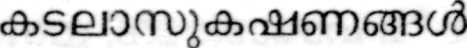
കടലാസുകഷണങ്ങള്‍
